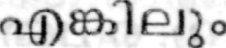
എങ്കിലും
